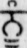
ਨੂੰ
